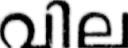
വില
